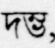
দম্ভ,
